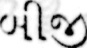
બીજી
